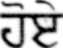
ਹੋਏ
